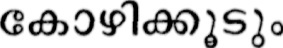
കോഴിക്കൂടും
